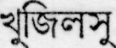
খূজিলসু
